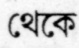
থেকে
